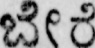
ಬೇರೆ
